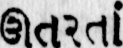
ઊતરતાં
